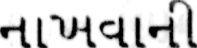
નાખવાની
